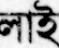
লাই
